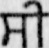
ਸੀ
